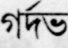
গর্দভ
